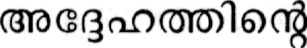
അദ്ദേഹത്തിന്റെ
